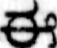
ಈ
